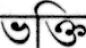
ভক্তি
